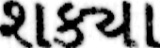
શક્યા
